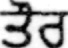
ਤੌਰ
